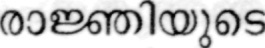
രാജ്ഞിയുടെ
